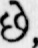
છે,
